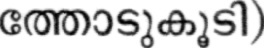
ത്തോടുകൂടി)
